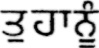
ਤੁਹਾਨੂੰ
